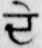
ਦੇ
